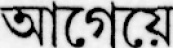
আগেয়ে
